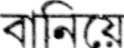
বানিয়ে
